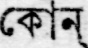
কোন্
